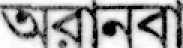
অরানবা
